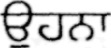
ਉਹਨਾ
